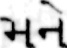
મને
